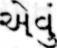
એવું
